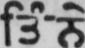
ਤਿੰਨੇ
